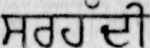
ਸਰਹੱਦੀ
